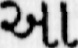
આ
